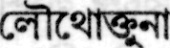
লৌথোক্তুনা
